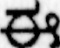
ಈ
